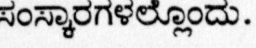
ಸಂಸ್ಕಾರಗಳಲ್ಲೊಂದು.
